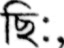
ছি:,
